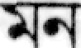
মন
